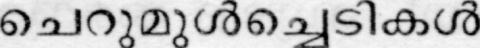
ചെറുമുള്‍ച്ചെടികള്‍
